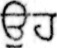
ਉਹ
